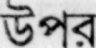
উপর
